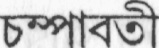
চম্পাবতী
